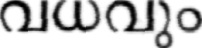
വധവും
